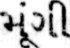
મૂંગી
